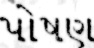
પોષણ
